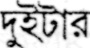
দুইটার
